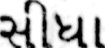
સીધા
